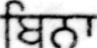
ਬਿਨਾ
